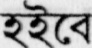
হইবে
